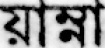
য়াম্না
